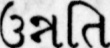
ઉન્નતિ
